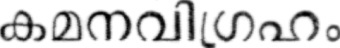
കമനവിഗ്രഹം
